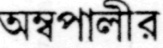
অম্বপালীর
